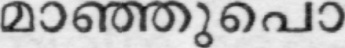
മാഞ്ഞുപൊ
